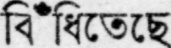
বিঁধিতেছে
